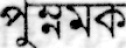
পুম্নমক
